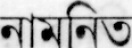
নামনিত
